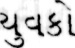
યુવકો
